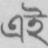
এই
